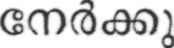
നേര്‍ക്കു
